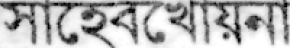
সাহেবখোয়না
